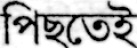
পিছতেই
